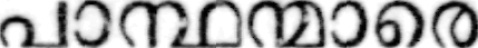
പാന്ഥന്മാരെ
